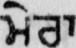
ਮੇਰਾ
